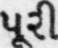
પૂરી
